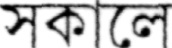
সকালে
